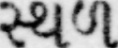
સ્થળ
